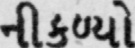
નીકળ્યો
